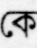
কে
